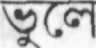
ভুলে
